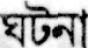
ঘটনা
